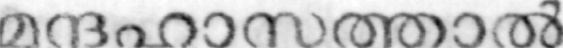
മന്ദഹാസത്താല്‍
